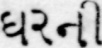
ઘરની
